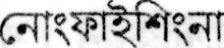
নোংফাইশিংনা
